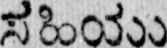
ಸಹಿಯು
